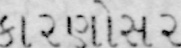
કારણોસર
